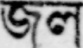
জল
